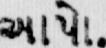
આપો.
